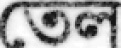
তেল
